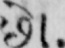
છો.
